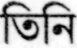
তিনি
